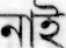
নাই
